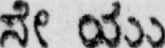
ಸೇಯು
